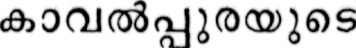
കാവല്‍പ്പുരയുടെ
